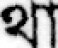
থা
